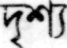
দৃশ্য
